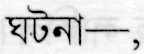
ঘটনা-,
